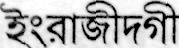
ইংরাজীদগী
